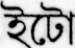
ইটো
